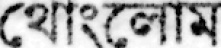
থোংলোম
